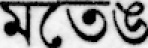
মতেঙ
